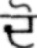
ਦੋ
